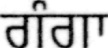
ਗੰਗਾ
